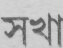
সখা
